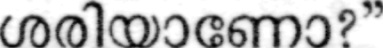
ശരിയാണോ?”
